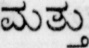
ಮತ್ತು
